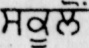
ਸਕੂਲੋਂ
